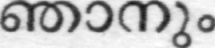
ഞാനും
